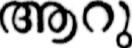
ആറു
